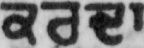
ਕਰਦਾ
